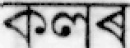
কলৰ
